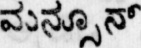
ಮನ್ಸೂನ್
